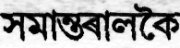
সমান্তৰালকৈ
